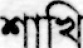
শাখি
